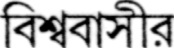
বিশ্ববাসীর
